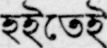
হইতেই
